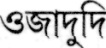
ওজাদুদি
